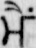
ਮੈਂ
